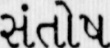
સંતોષ
